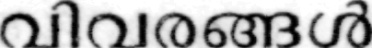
വിവരങ്ങള്‍
